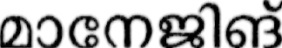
മാനേജിങ്
